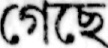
গেছে
